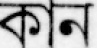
কান
